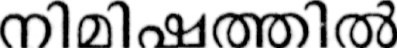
നിമിഷത്തില്‍
